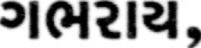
ગભરાય,
